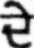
ਦੇ
